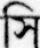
সি
